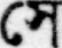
সে
